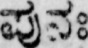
ಪುನಃ
